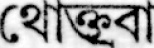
থোক্ত্রবা
